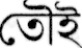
তৌই
